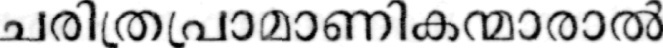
ചരിത്രപ്രാമാണികന്മാരാല്‍
